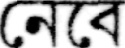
নেবে
